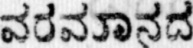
ವರಮಾನದ
